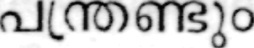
പന്ത്രണ്ടും
